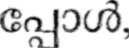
പ്പോള്‍,
